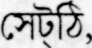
সেট্ঠি,
